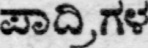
ಪಾದ್ರಿಗಳ
